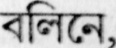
বলিনে,
